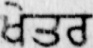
ਖੇਤਰ
